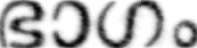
ഭാഗം
